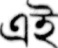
এই
